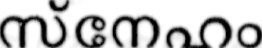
സ്നേഹം
